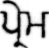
ਪ੍ਰੇਮ
